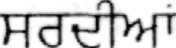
ਸਰਦੀਆਂ
